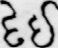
દેઈ
